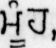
ਮੂੰਹ,
